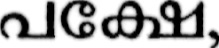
പക്ഷേ,
